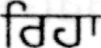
ਰਿਹਾ
